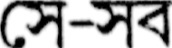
সে-সব
